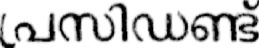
പ്രസിഡണ്ട്
